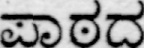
ಪಾಠದ
